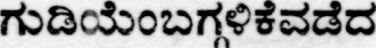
ಗುಡಿಯೆಂಬಗ್ಗಳಿಕೆವಡೆದ
